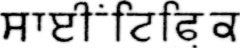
ਸਾਈਂਟਿਫ਼ਿਕ
